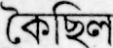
কৈছিল
